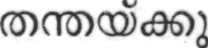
തന്തയ്ക്കു
